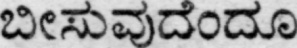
ಬೀಸುವುದೆಂದೂ
